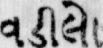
વડીલો
